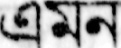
এমন
